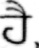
ਹੈ,
